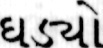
ઘડ્યો
